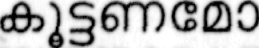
കൂട്ടണമോ
